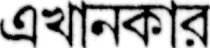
এখানকার
